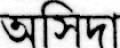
অসিদা
